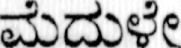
ಮೆದುಳೇ
